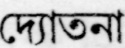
দ্যোতনা
